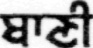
ਬਾਣੀ
